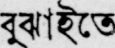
বুঝাইতে
